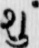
શું
